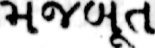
મજબૂત
